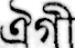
ঐগী
